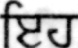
ਇਹ
